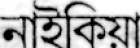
নাইকিয়া
